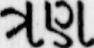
ત્રણ
